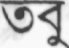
তবু
